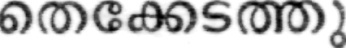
തെക്കേടത്തു
